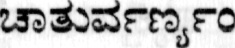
ಚಾತುರ್ವರ್ಣ್ಯಂ
